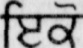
ਇਕੋ
